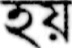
হয়
